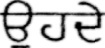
ਉਹਦੇ
